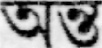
অন্ত
